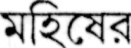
মহিষের
